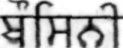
ਬੌਸਿਨੀ
